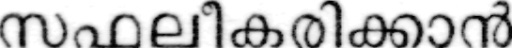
സഫലീകരിക്കാന്‍
